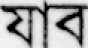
যাব
